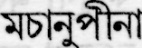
মচানুপীনা
